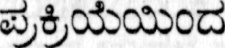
ಪ್ರಕ್ರಿಯೆಯಿಂದ
